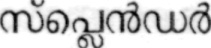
സ്പ്ലെന്‍ഡര്‍
